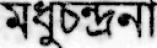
মধুচন্দ্রনা
